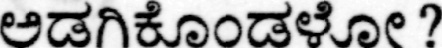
ಅಡಗಿಕೊಂಡಳೋ?
